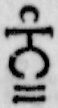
ਨੂੰ
